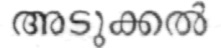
അടുക്കല്‍
